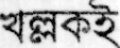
খল্লকই
